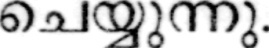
ചെയ്യുന്നു.
